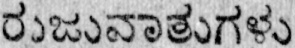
ರುಜುವಾತುಗಳು
